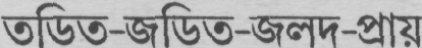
তড়িত-জড়িত-জলদ-প্ৰায়
